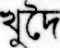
খুদৈ
